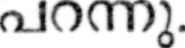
പറന്നു.
